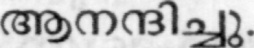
ആനന്ദിച്ചു.
